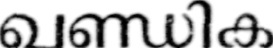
ഖണ്ഡിക
